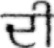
ਦੀ
